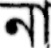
না
